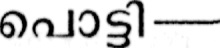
പൊട്ടി-
